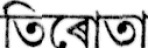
তিৰোতা
